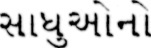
સાધુઓનો
